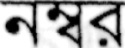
নম্বর
